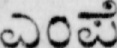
ಎಂಪೆ
